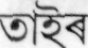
তাইৰ
